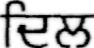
ਦਿਲ
